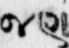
જણ
